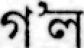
গ'ল
